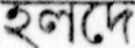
হলদে
